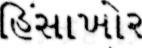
હિંસાખોર
